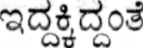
ಇದ್ದಕ್ಕಿದ್ದಂತೆ
